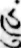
હું
